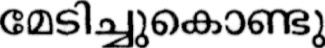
മേടിച്ചുകൊണ്ടു
